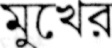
মুখের
